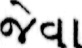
જેવા
